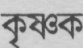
কৃষ্ণক
